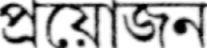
প্রয়োজন
